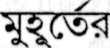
মুহূর্তের
